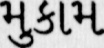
મુકામ
